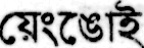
য়েংঙোই
